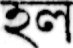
হল
